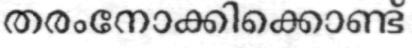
തരംനോക്കിക്കൊണ്ട്
